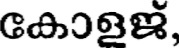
കോളജ്,
